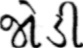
જોડી
